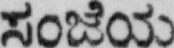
ಸಂಜೆಯ
